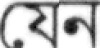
যেন
